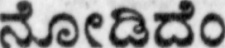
ನೋಡಿದೆಂ
